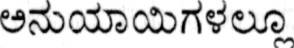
ಅನುಯಾಯಿಗಳಲ್ಲೂ
